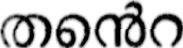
തന്റെ
